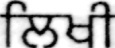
ਲਿਖੀ
